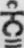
ਨੂੰ
